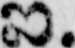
ಐ.
